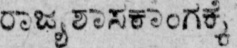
ರಾಜ್ಯಶಾಸಕಾಂಗಕ್ಕೆ
